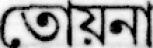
তোয়না
